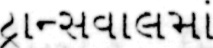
ટ્રાન્સવાલમાં
